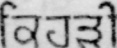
ਕਿਹੜੀ
